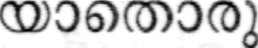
യാതൊരു
